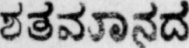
ಶತಮಾನದ
